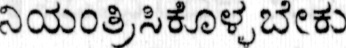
ನಿಯಂತ್ರಿಸಿಕೊಳ್ಳಬೇಕು
